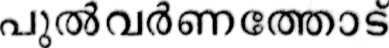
പുല്‍വര്‍ണത്തോട്
